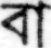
বা
